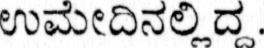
ಉಮೇದಿನಲ್ಲಿದ್ದ.
